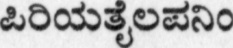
ಪಿರಿಯತೈಲಪನಿಂ
